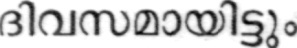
ദിവസമായിട്ടും
